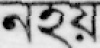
নহয়
